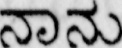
ನಾನು
